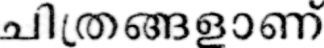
ചിത്രങ്ങളാണ്
